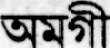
অমগী
